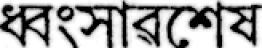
ধ্বংসাৱশেষ
